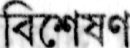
বিশেষণ
